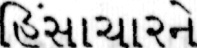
હિંસાચારને
